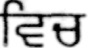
ਵਿਚ
